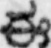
ಈ
